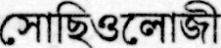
সোছিওলোজী
